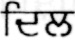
ਦਿਲ
